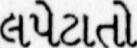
લપેટાતો
